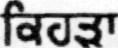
ਕਿਹੜਾ
